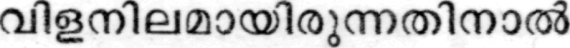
വിളനിലമായിരുന്നതിനാല്‍
